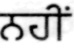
ਨਹੀਂ
